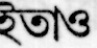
ইতাও
